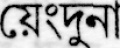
য়েংদুনা
